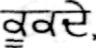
ਕੂਕਦੇ,
